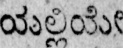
ಯಲ್ಲಿಯೇ
